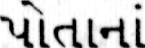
પોતાનાં
